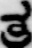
ತ
